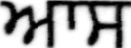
ਆਸ
